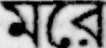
মরে
